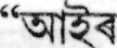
"আইৰ
